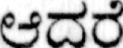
ಆದರೆ
